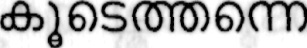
കുടെത്തന്നെ
